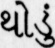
થોડું
